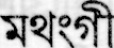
মথংগী
